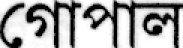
গোপাল
